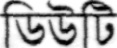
ডিউটি
